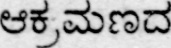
ಆಕ್ರಮಣದ
